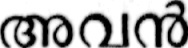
അവന്‍
